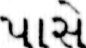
પાસે
